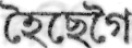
হৈছেগৈ
